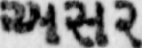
અસર
